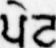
ਪੇਟ
